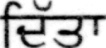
ਦਿੱਤਾ
